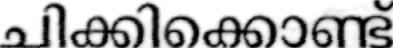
ചിക്കിക്കൊണ്ട്
